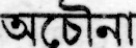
অচৌনা
